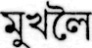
মুখলৈ
